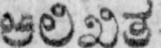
ಅಲಿಖಿತ
